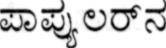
ಪಾಪ್ಯುಲರ್ನ
